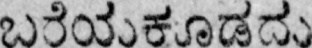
ಬರೆಯಕೂಡದು
